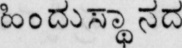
ಹಿಂದುಸ್ಥಾನದ
